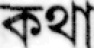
কথা
